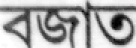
বজাত
